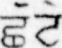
ਛੋਟੇ
